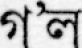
গ'ল
